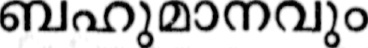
ബഹുമാനവും
